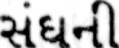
સંઘની
